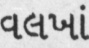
વલખાં
